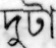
দুটা
